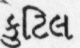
કુટિલ
